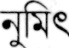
নুমিৎ
